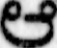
ಆ
